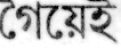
গৈয়েই
